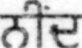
ਨੀਂਦ
